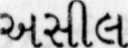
અસીલ
